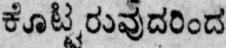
ಕೊಟ್ಟಿರುವುದರಿಂದ
